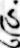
હું
